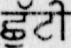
ਛੁੱਟੀ
